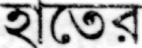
হাতের
